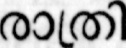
രാത്രി
